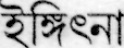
ইঙ্গিৎনা
